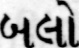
બલો
